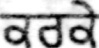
ਕਰਕੇ
